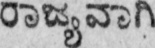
ರಾಜ್ಯವಾಗಿ
